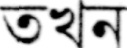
তখন
